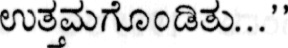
ಉತ್ತಮಗೊಂಡಿತು..."
